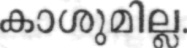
കാശുമില്ല.
